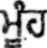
ਮੂੰਹ
